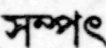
সম্পত্
